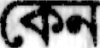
কেন
